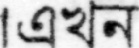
৷এখন
